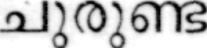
ചുരുണ്ട
